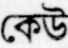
কেউ
